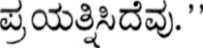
ಪ್ರಯತ್ನಿಸಿದೆವು."
